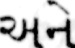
અને
